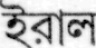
ইরাল
